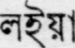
লইয়া
